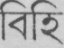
বিহি
